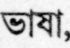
ভাষা,
